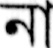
না
